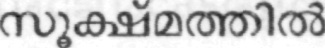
സൂക്ഷ്മത്തില്‍
